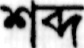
শব্দ
